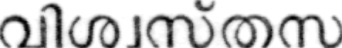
വിശ്വസ്തസ
